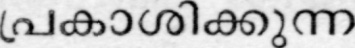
പ്രകാശിക്കുന്ന
